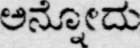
ಅನ್ನೋದು
